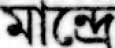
মান্দ্রে
